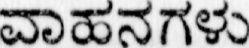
ವಾಹನಗಳು
